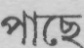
পাছে
